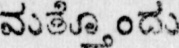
ಮತ್ತೊಂದು
